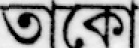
তাকো
